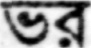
ভর
